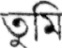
তুমি
